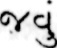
જવું
